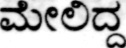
ಮೇಲಿದ್ದ
